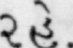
રહે.
